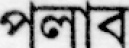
পলাব
